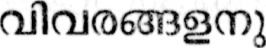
വിവരങ്ങളനു
